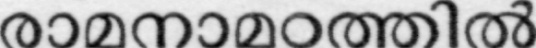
രാമനാമഠത്തില്‍
